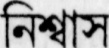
নিশ্বাস
